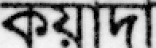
কয়াদা
